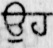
ਉਹ
